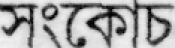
সংকোচ
